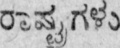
ರಾಷ್ಟ್ರಗಳು
